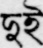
দুই
